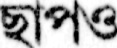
ছাপও
